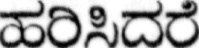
ಹರಿಸಿದರೆ
